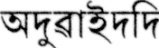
অদুৱাইদদি
